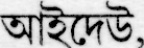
আইদেউ,
